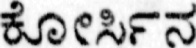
ಕೋರ್ಸಿನ
